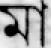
মা
